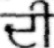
ਦੀ
